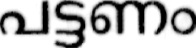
പട്ടണം
